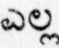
ಎಲ್ಲ
